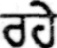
ਰਹੇ
